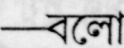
–বলো
